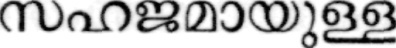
സഹജമായുള്ള
